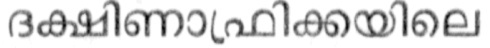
ദക്ഷിണാഫ്രിക്കയിലെ
